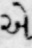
એ
